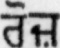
ਰੋਜ਼
